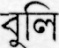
বুলি
